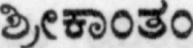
ಶ್ರೀಕಾಂತಂ
